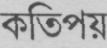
কতিপয়
